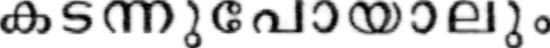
കടന്നുപോയാലും
